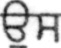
ਉਸ
